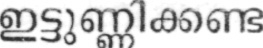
ഇട്ടുണ്ണിക്കണ്ട
